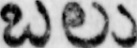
ಬಲು
